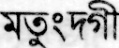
মতুংদগী
